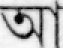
আ
